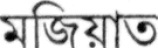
মজিয়াত
